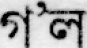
গ'ল
